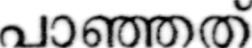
പാഞ്ഞത്
